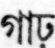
গাঢ়
